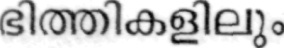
ഭിത്തികളിലും
